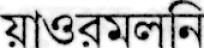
য়াওরমলনি
